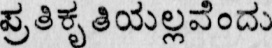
ಪ್ರತಿಕೃತಿಯಲ್ಲವೆಂದು
